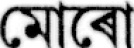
মোৰো
